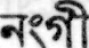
নংগী
